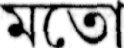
মতো
